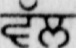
ਵੱਲ
